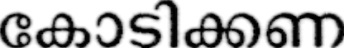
കോടിക്കണ
